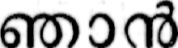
ഞാന്‍
